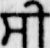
ਸੀ
